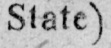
State)
